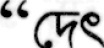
“দেৎ
